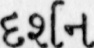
દર્શન
